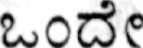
ಒಂದೇ
